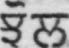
ਝੋਲ
